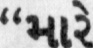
“મારે
